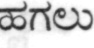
ಹಗಲು
